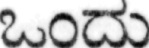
ಒಂದು
